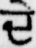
ਦੇ
